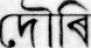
দৌৰি
